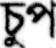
চুপ
